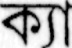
ক্যা
